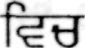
ਵਿਚ
